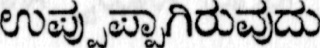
ಉಪ್ಪುಪ್ಪಾಗಿರುವುದು
